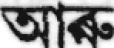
আৰু
